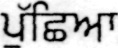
ਪੁੱਛਿਆ
